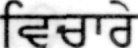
ਵਿਚਾਰੇ
